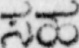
ಸಹ
